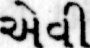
એવી
